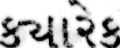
ક્યારેક
